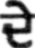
ਦੇ
